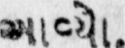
આવ્યો.
